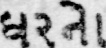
ઘરનો
